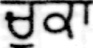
ਚੁਕਾ
